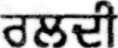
ਰਲਦੀ
